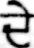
ਦੇ
